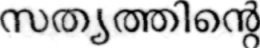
സത്യത്തിന്റെ
